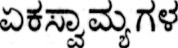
ಏಕಸ್ವಾಮ್ಯಗಳ
